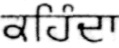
ਕਹਿੰਦਾ
